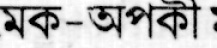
মেক-অপকী
